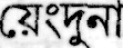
য়েংদুনা
